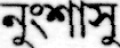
নুংশাসু
